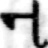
ન
